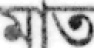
মাত
